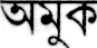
অমুক
